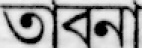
তাবনা
